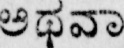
ಅಥವಾ
